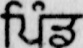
ਪਿੰਡ
